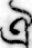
ঐ
